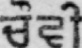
ਚੌਵੀ
